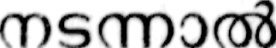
നടന്നാല്‍
